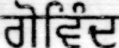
ਗੋਵਿੰਦ
